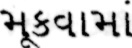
મૂકવામાં
